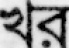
খর
